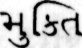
મુક્તિ
